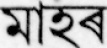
মাহৰ
